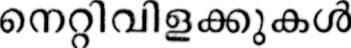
നെറ്റിവിളക്കുകള്‍
